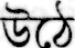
উঠে
